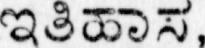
ಇತಿಹಾಸ,
